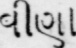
વીણા
